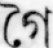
গৈ
